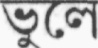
ভুলে
